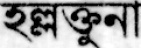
হল্লক্তুনা
